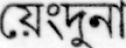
য়েংদুনা
